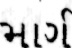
માર્ગ
